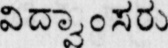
ವಿದ್ವಾಂಸರು
